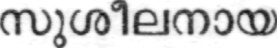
സുശീലനായ
